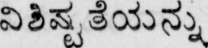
ವಿಶಿಷ್ಟತೆಯನ್ನು
